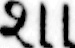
શા
